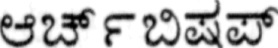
ಆರ್ಚ್ ಬಿಷಪ್
